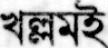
খল্লমই
